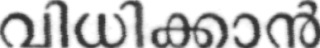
വിധിക്കാന്‍
